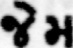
જેમ
